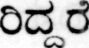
ರಿದ್ದರೆ
